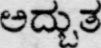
ಅದ್ಭುತ
